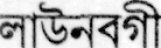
লাউনবগী
